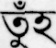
তুঁহ
